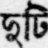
দুটি
